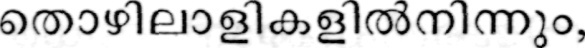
തൊഴിലാളികളില്‍നിന്നും,
